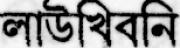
লাউখিবনি
